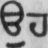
ਉਹ
